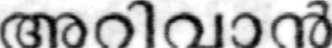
അറിവാന്‍
